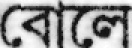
বোলে
